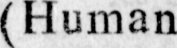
(Human
